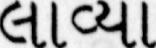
લાવ્યા
